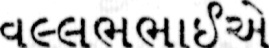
વલ્લભભાઈએ
